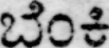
ಬೆಂಕಿ
